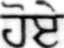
ਹੋਏ
